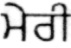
ਮੇਰੀ
